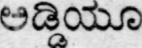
ಅಡ್ಡಿಯೂ
